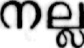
നല്ല
